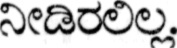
ನೀಡಿರಲಿಲ್ಲ.
